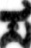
ಸ
